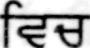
ਵਿਚ
